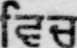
ਵਿਚ
